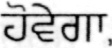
ਹੋਵੇਗਾ,
